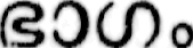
ഭാഗം
